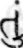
તું
